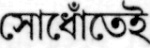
সোধোঁতেই
